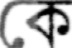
কে
